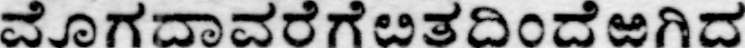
ಮೊಗದಾವರೆಗೆೞತದಿಂದೆಱಗಿದ
